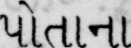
પોતાના
